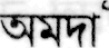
অমদা
